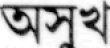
অসুখ
